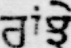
ਰਾਂਝੇ
